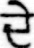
ਦੇ
